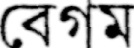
বেগম
